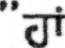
''ਹਾਂ
